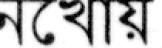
নখোয়
